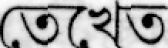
তেখেত
